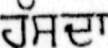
ਹੱਸਦਾ
